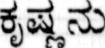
ಕೃಷ್ಣನು
